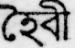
হৈবী
